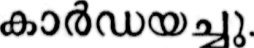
കാര്‍ഡയച്ചു.
